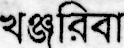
খঞ্জরিবা
